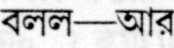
বলল–আর
